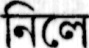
নিলে
